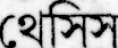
থেসিস
